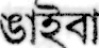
ঙাইবা
